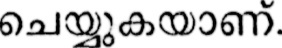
ചെയ്യുകയാണ്.
